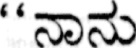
"ನಾನು
